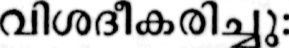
വിശദീകരിച്ചു:
